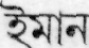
ইমান
